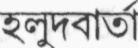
হলুদবার্তা
